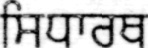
ਸਿਧਾਰਥ
